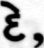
દે,
